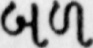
બળ
